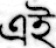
এই
